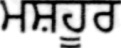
ਮਸ਼ਹੂਰ
